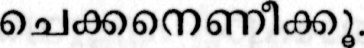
ചെക്കനെണീക്കൂ.
